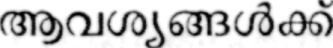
ആവശ്യങ്ങള്‍ക്ക്
